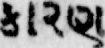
કારણ
